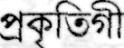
প্রকৃতিগী
